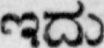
ಇದು
